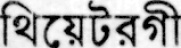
থিয়েটরগী
